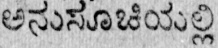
ಅನುಸೂಚಿಯಲ್ಲಿ
